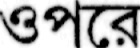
ওপরে
